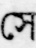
সে
